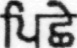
ਪਿਛੇ
